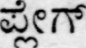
ಪ್ಲೇಗ್
